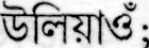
উলিয়াওঁ;
